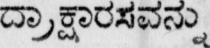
ದ್ರಾಕ್ಷಾರಸವನ್ನು
